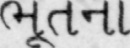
ભૂતના
